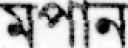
মপান
